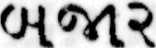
બજાર
